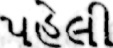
પહેલી
